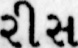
રીસ
